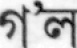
গ'ল
